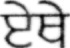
ਏਥੇ
